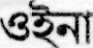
ওইনা
